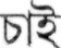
চাই
